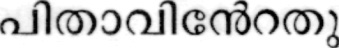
പിതാവിന്റേതു
